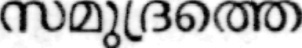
സമുദ്രത്തെ
